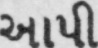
આપી
